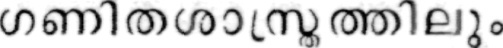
ഗണിതശാസ്ത്രത്തിലും
